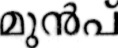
മുന്‍പ്
